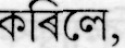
কৰিলে,
